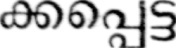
ക്കപ്പെട്ട
